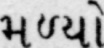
મળ્યો
